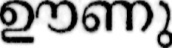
ഊണു
